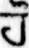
ਹੋ
